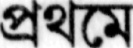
প্রথমে
